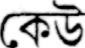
কেউ
